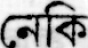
নেকি
